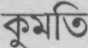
কুমতি
